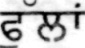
ਫੁੱਲਾਂ
